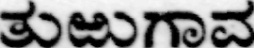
ತುಱುಗಾವ
